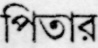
পিতার
